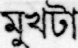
মুখটা
